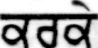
ਕਰਕੇ
